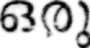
ഒരു
